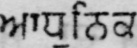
ਆਧੁਨਿਕ
